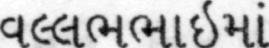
વલ્લભભાઈમાં
